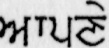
ਆਪਣੇ
